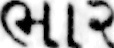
ભાર
